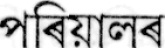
পৰিয়ালৰ
